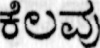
ಕೆಲವು
